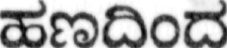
ಹಣದಿಂದ
